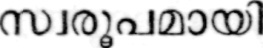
സ്വരൂപമായി
